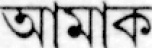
আমাক
